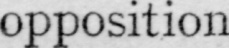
opposition
